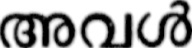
അവള്‍
